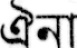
ঐনা
